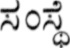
ಸಂಸ್ಥೆ
